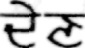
ਦੇਣ
